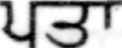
ਪਤਾ
